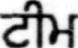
ਟੀਮ
